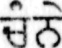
ਚੰਨੇ
